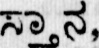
ಸ್ತಾನ,
